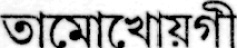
তামোখোয়গী
